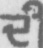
ਦੀ
